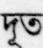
দূত
